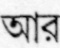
আর
